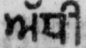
ਅੱਧੀ
